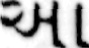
આ
